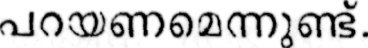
പറയണമെന്നുണ്ട്.
